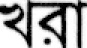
খরা
